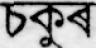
চকুৰ
